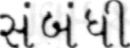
સંબંધી
